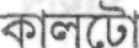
কালটো
